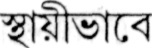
স্থায়ীভাবে
